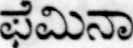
ಫೆಮಿನಾ
